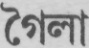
গৈলা
